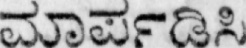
ಮಾರ್ಪಡಿಸಿ
